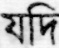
যদি
